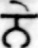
ਨੇ
